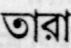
তারা
